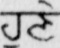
ਹੁਣੇ
